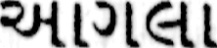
આગલા
